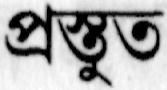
প্রস্তুত
